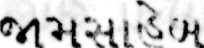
જામસાહેબ
